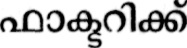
ഫാക്ടറിക്ക്
